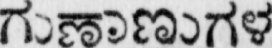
ಗುಣಾಣುಗಳ
